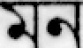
মন
